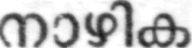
നാഴിക
